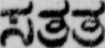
ಸತತ
